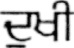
ਦੁਖੀ
